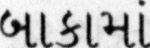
બાકામાં
